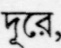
দূরে,
